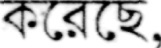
করেছে,
